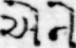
એને
